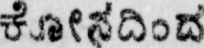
ಕೋನದಿಂದ
